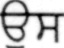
ਉਸ
